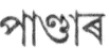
পাণ্ডাৰ
